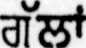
ਗੱਲਾਂ
